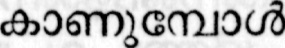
കാണുമ്പോള്‍
